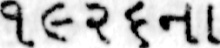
૧૯૨૬ના
